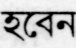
হবেন
